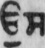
ਉਸ
